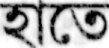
হাতে
